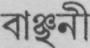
বাঞ্ছনী
